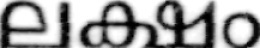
ലക്ഷം
